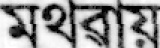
মথৱায়
